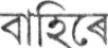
বাহিৰে
